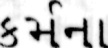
કર્મના
